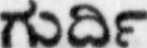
ಗುರ್ದಿ
